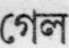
গেল
